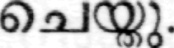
ചെയ്തു.
